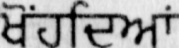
ਖੋਂਹਦਿਆਂ
